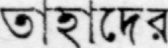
তাহাদের
